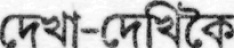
দেখা-দেখিকৈ
